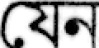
যেন
